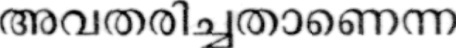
അവതരിച്ചതാണെന്ന
